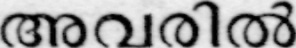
അവരില്‍
